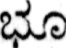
ಭೂ
